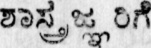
ಶಾಸ್ತ್ರಜ್ಞರಿಗೆ
